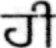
ਹੀ
